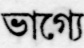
ভাগ্যে
